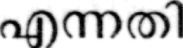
എന്നതി
